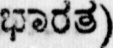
ಭಾರತ)
